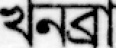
খনব্রা
